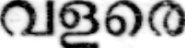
വളരെ
